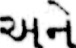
અને
